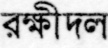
রক্ষীদল
